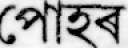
পোহৰ
